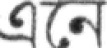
এনে
